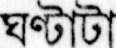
ঘণ্টাটা
